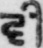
ਵੀ
